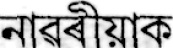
নাৱৰীয়াক
